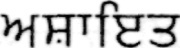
ਅਸ਼ਾਇਤ
